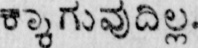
ಕ್ಕಾಗುವುದಿಲ್ಲ.
